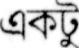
একটু
